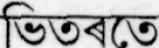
ভিতৰতে
